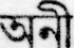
অনী
